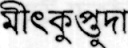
মীৎকুপ্তুদা
